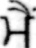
ਮੈਂ
